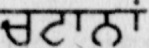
ਚਟਾਨਾਂ
